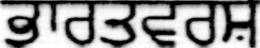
ਭਾਰਤਵਰਸ਼
